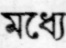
মধ্যে
